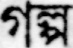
গল্প
